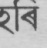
হৰি
